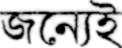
জন্যেই
